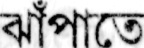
ঝাঁপাতে
